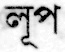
লূপ
